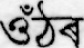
ওঁঠৰ
